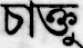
চাক্তু
